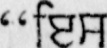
''ਇਸ
